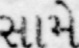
સામે
